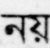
নয়
